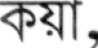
কয়া,
